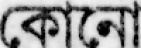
কোনো
